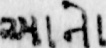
આનો
